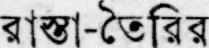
রাস্তা-তৈরির
